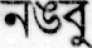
নঙবু
